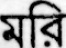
মরি
